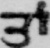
ਤਾਂ
